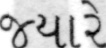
જ્યારે
